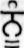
ਨੂੰ
